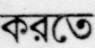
করতে
